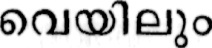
വെയിലും
